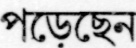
পড়েছেন
